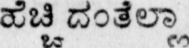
ಹೆಚ್ಚಿದಂತೆಲ್ಲಾ
